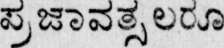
ಪ್ರಜಾವತ್ಸಲರೂ
